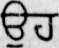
ਉਹ
